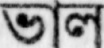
ভাল
